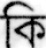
কি
